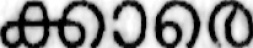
ക്കാരെ
